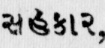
સહકાર,
